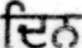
ਦਿਨ
